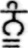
ਨੂੰ
